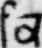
ਕਿ
